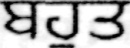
ਬਹੁਤ
